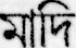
মাদি
